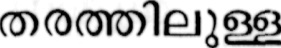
തരത്തിലുള്ള
